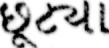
છૂટ્યા
